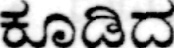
ಕೂಡಿದ
